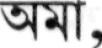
অমা,
